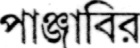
পাঞ্জাবির
